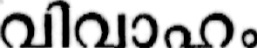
വിവാഹം
